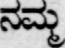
ನಮ್ಮ
